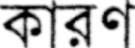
কারণ
